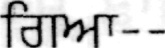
ਗਿਆ--
